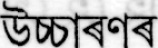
উচ্চাৰণৰ
